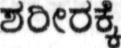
ಶರೀರಕ್ಕೆ
